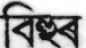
বিহুৰ
